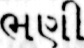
ભણી
